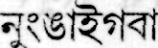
নুংঙাইগবা
